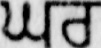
ਘਰ
